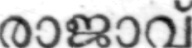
രാജാവ്
